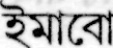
ইমাবো
